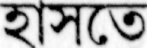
হাসতে
